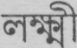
লক্ষ্মী
